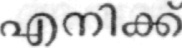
എനിക്ക്
